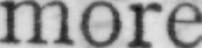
more
